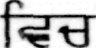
ਵਿਚ
